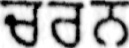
ਚਰਨ
